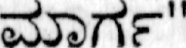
ಮಾರ್ಗ”
